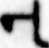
ન
